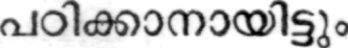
പഠിക്കാനായിട്ടും
